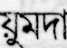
য়ুমদা
